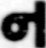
ન
